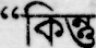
"কিন্তু
